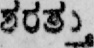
ಶರತ್ತು
